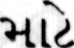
માટે
